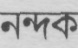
নন্দক
